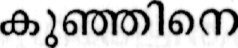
കുഞ്ഞിനെ
